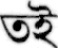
তই
